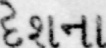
દેશના
